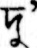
দু'
